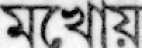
মখোয়
